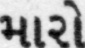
મારો
